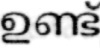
ഉണ്ട്
